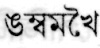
ঙম্বমখৈ
